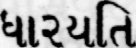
ધારયતિ
